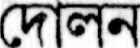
দোলন
